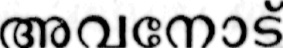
അവനോട്
